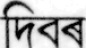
দিবৰ
